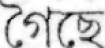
গৈছে
